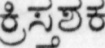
ಕ್ರಿಸ್ತಶಕ
